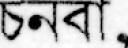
চনবা,
